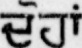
ਦੋਹਾਂ
